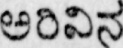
ಅರಿವಿನ
